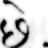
છે.
